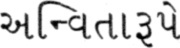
અન્વિતારૂપે
